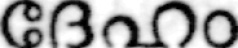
ദേഹം
